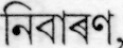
নিবাৰণ,
